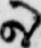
જે
